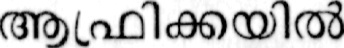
ആഫ്രിക്കയില്‍
